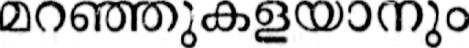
മറഞ്ഞുകളയാനും
